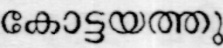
കോട്ടയത്തു
